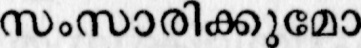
സംസാരിക്കുമോ
